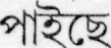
পাইছে
